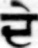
ਦੇ
